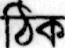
ঠিক
